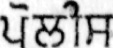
ਪੋਲੀਸ
